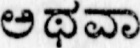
ಅಥವಾ
